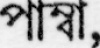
পাম্বা,
